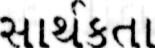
સાર્થકતા
